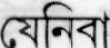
যেনিবা
